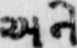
અને
